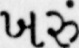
ખરું
